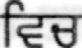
ਵਿਚ
